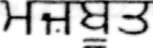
ਮਜ਼ਬੂਤ
